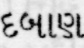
દબાણ
